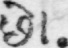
છો.
